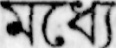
মধ্যে
